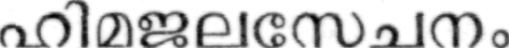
ഹിമജലസേചനം
